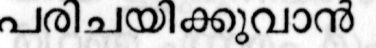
പരിചയിക്കുവാന്‍
